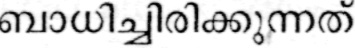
ബാധിച്ചിരിക്കുന്നത്
